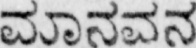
ಮಾನವನ
